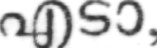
എടാ,
